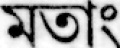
মতাং
